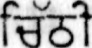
ਚਿੱਠੀ
